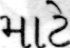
માટે
